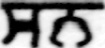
ਸਨ
